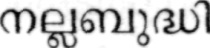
നല്ലബുദ്ധി
